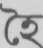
হৈ
